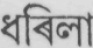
ধৰিলা
